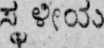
ಸ್ಥಳೀಯ
